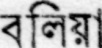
বলিয়া
